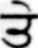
ਤੇ
